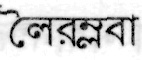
লৈরম্লবা
